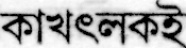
কাখৎলকই
